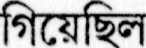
গিয়েছিল
